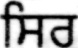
ਸਿਰ
